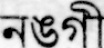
নঙগী
